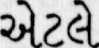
એટલે
